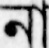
না
